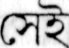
সেই
